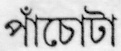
পাঁচোটা
